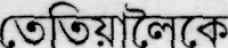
তেতিয়ালৈকে
